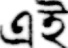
এই
